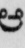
ಆ
